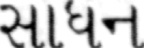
સાધન
